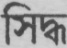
সিদ্ধ
